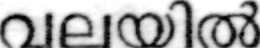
വലയില്‍
